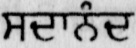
ਸਦਾਨੰਦ
